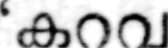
‘കറവ
